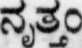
ನೃತ್ತಂ
